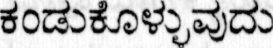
ಕಂಡುಕೊಳ್ಳುವುದು
